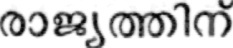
രാജ്യത്തിന്
